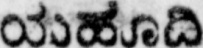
ಯಹೂದಿ
